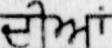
ਦੀਆ
